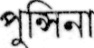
পুন্সিনা
